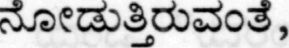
ನೋಡುತ್ತಿರುವಂತೆ,
